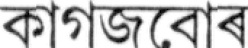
কাগজবোৰ
